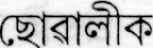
ছোৱালীক
